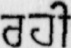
ਰਹੀ
